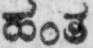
ಹಂತ
